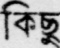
কিছু
